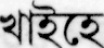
খাইহে
